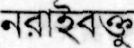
নরাইবক্তু
